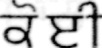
ਕੋਈ
